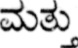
ಮತ್ತು
